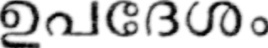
ഉപദേശം
